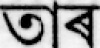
তাৰ
